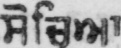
ਸੋਚਿਆ
